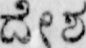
ದೇಶ
